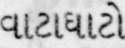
વાટાઘાટો
